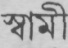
স্বামী
